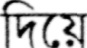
দিয়ে
